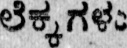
ಲೆಕ್ಕಗಳು.
